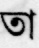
তা
